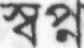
স্বপ্ন
